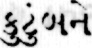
કુટુંબને
